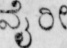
ವೈರೀ
